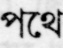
পথে
